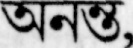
অনন্ত,
